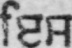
ਇਸ
